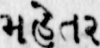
મહેતર
